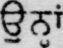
ਉਨ੍ਹਾਂ
